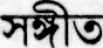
সঙ্গীত
